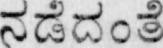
ನಡೆದಂತೆ
